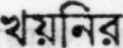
খয়নির
